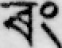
ৰং
